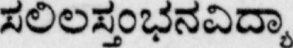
ಸಲಿಲಸ್ತಂಭನವಿದ್ಯಾ
